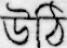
উঠি
